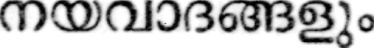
നയവാദങ്ങളും
